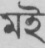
মই
